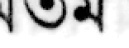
মতম
